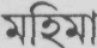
মহিমা
